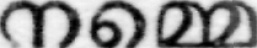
നമ്മെ
